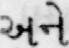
અને
